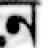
নে
